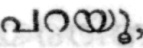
പറയൂ,
